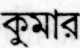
কুমার
